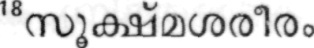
18സൂക്ഷ്മശരീരം
